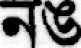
নঙ
